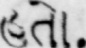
હતો.
